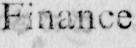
Finance
